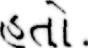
હતો.
